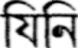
যিনি
